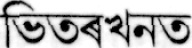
ভিতৰখনত
